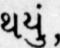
થયું,
